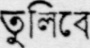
তুলিবে
